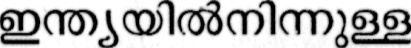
ഇന്ത്യയില്‍നിന്നുള്ള
